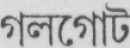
গলগোট
